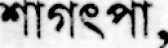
শাগৎপা,
